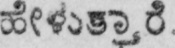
ಹೇಳುತ್ತಾರೆ.
